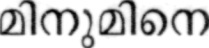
മിനുമിനെ
